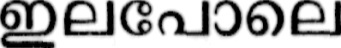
ഇലപോലെ
